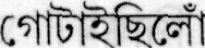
গোটাইছিলোঁ
